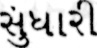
સુધારી
